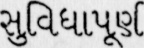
સુવિધાપૂર્ણ
